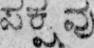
ಪಕ್ಷವು
